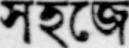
সহজে
